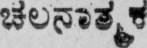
ಚಲನಾತ್ಮಕ
